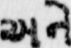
અને
